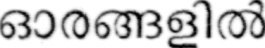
ഓരങ്ങളില്‍
